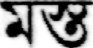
মস্ত
